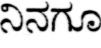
ನಿನಗೂ
